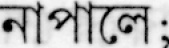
নাপালে;
